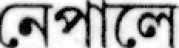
নেপালে
